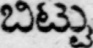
ಬಿಟ್ಟು
